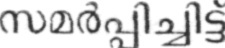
സമര്‍പ്പിച്ചിട്ട്
